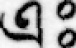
এঃ
